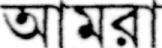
আমরা
